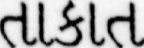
તાકાત
